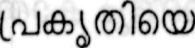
പ്രകൃതിയെ
